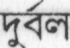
দুর্বল
